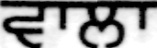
ਵਾਲਾ
